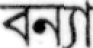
বন্যা
